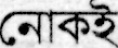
নোকই
